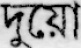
দুয়ো
